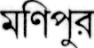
মণিপুর
